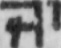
ਜਾ
